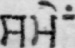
ਸਮੇਂ
